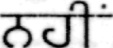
ਨਹੀਂ
